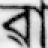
ৱা
